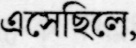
এসেছিলে,
